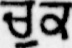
ਚੁਕ
